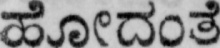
ಹೋದಂತೆ
